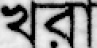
খরা
